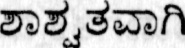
ಶಾಶ್ವತವಾಗಿ
